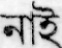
নাই
